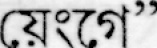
য়েংগে”
